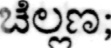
ಚೆಲ್ಲಣ;
